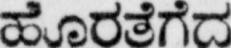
ಹೊರತೆಗೆದ
